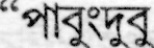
“পাবুংদুবু
